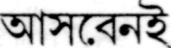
আসবেনই
